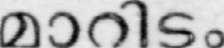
മാറിടം
